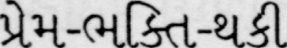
પ્રેમ-ભક્તિ-થકી
